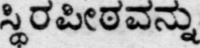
ಸ್ಥಿರಪೀಠವನ್ನು
